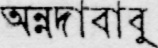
অন্নদাবাবু
